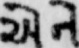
એને
